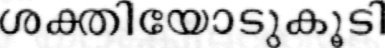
ശക്തിയോടുകൂടി
